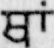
ਥਾਂ
